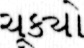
ચૂક્યો
